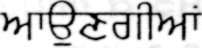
ਆਉਣਗੀਆਂ
